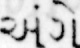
અંગે
